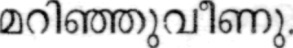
മറിഞ്ഞുവീണു.
